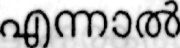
എന്നാല്‍
